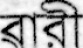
ৱারী
